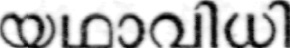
യഥാവിധി
